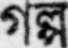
গল্প
